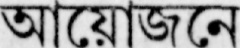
আয়োজনে
